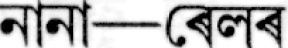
নানা-ৰেলৰ
